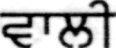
ਵਾਲੀ
